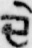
ਦੇ
